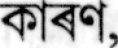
কাৰণ,
